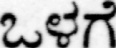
ಒಳಗೆ
